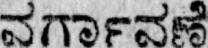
ವರ್ಗಾವಣೆ
